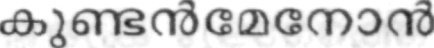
കുണ്ടന്‍മേനോന്‍
